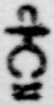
ਨੂੰ
